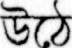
উঠে
